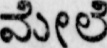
ಮೇಲೆ
